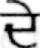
ਦੇ
